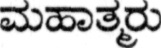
ಮಹಾತ್ಮರು
